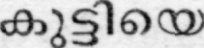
കുട്ടിയെ
